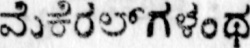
ಮೆಕೆರಲ್‌ಗಳಂಥ
